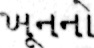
ખૂનનો
